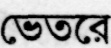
ভেতরে
